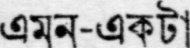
এমন-একটা
